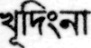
খূদিংনা
